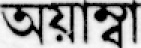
অয়াম্বা
